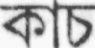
কাচ
